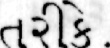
તરીકે.
